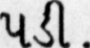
પડી.
